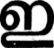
ഇ
